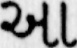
આ
